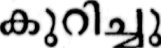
കുറിച്ചു
